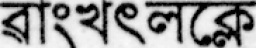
ৱাংখৎলক্লে
